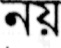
নয়
